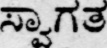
ಸ್ವಾಗತ
